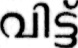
വിട്ട്
